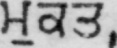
ਮੁਕਤ,
